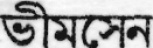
ভীমসেন
